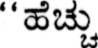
"ಹೆಚ್ಚು
